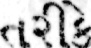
તરીકે
